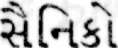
સૈનિકો
